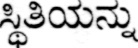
ಸ್ಥಿತಿಯನ್ನು
